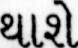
થાશે
